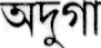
অদুগা
